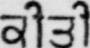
ਕੀਤੀ
